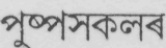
পুষ্পসকলৰ
